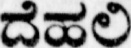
ದೆಹಲಿ
